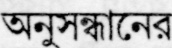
অনুসন্ধানের
